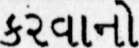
કરવાનો
